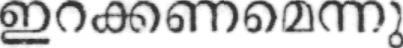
ഇറക്കണമെന്നു
